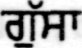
ਗੁੱਸਾ
